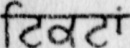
ਟਿਕਟਾਂ
